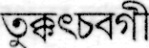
তুক্কৎচবগী
